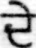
ਦੇ
